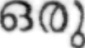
ഒരു
